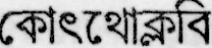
কোৎথোক্লবি
